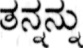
ತನ್ನನ್ನು
